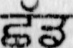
ਛੱਡ
